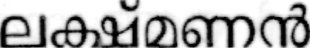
ലക്ഷ്മണന്‍
